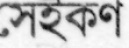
সেহকণ
